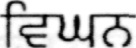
ਵਿਘਨ
